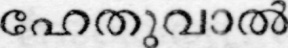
ഹേതുവാല്‍
